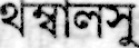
থম্বালসু
